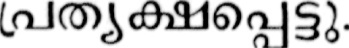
പ്രത്യക്ഷപ്പെട്ടു.
